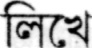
লিখে
